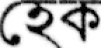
হেক
